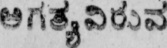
ಅಗತ್ಯವಿರುವ
